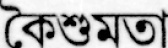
কৈশুমতা
